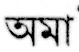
অমা
